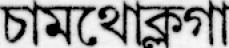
চামথোক্লগা
